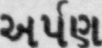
અર્પણ
